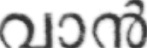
വാന്‍
